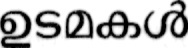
ഉടമകള്‍
